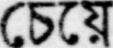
চেয়ে
